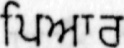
ਪਿਆਰ
